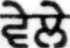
ਵੇਲੇ
